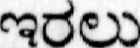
ಇರಲು
